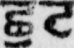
ਛੁਟ
